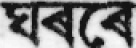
ঘৰৰে
